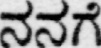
ನನಗೆ
